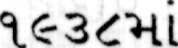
૧૯૩૮માં
